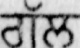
ਗੱਲ
